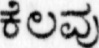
ಕೆಲವು
